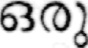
ഒരു
